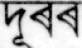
দূৰৰ
